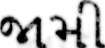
જામી
